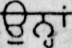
ਉਨ੍ਹਾਂ
